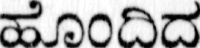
ಹೊಂದಿದ
